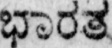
ಭಾರತ
